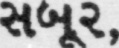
સબૂર,
